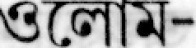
ওলোম-
